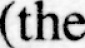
(the
